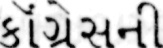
કૉંગ્રેસની
